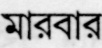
মারবার
